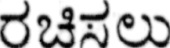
ರಚಿಸಲು
